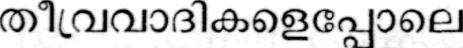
തീവ്രവാദികളെപ്പോലെ
